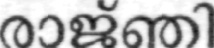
രാജ്ഞി
